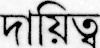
দায়িত্ব
